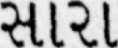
સારા
